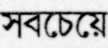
সবচেয়ে
